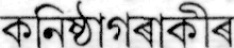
কনিষ্ঠাগৰাকীৰ
